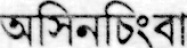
অসিনচিংবা
